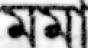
মমা
